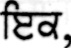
ਇਕ,
